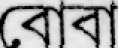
বোবা
